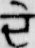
ਦੇ
